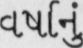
વર્ષાનું
